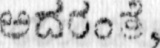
ಅದರಂತೆ,
